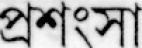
প্রশংসা
